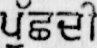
ਪੁੱਛਦੀ
